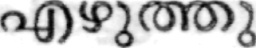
എഴുത്തു
